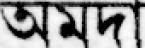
অমদা
